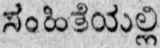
ಸಂಹಿತೆಯಲ್ಲಿ
